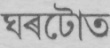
ঘৰটোত
